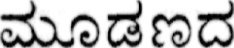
ಮೂಡಣದ
